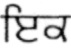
ਇਕ
